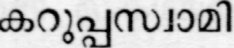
കറുപ്പസ്വാമി
